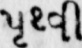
પૃથ્વી
